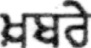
ਖ਼ਬਰੇ
